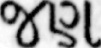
જણ
